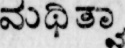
ಮಥಿತ್ವಾ
